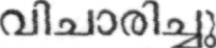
വിചാരിച്ചു
